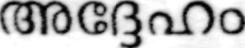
അദ്ദേഹം
